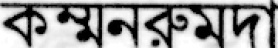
কম্মনরুমদা
